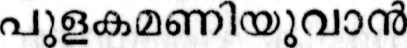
പുളകമണിയുവാന്‍
